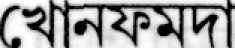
খোনফমদা
